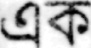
এক
